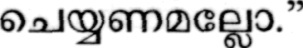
ചെയ്യണമല്ലോ."
